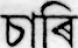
চাৰি
